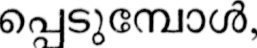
പ്പെടുമ്പോള്‍,
